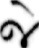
જે
